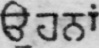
ਉਹਨਾਂ
